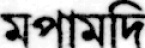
মপামদি
